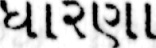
ધારણા
